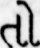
તો
